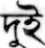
দুই
